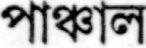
পাঞ্চাল
